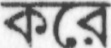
করে
